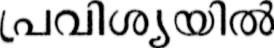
പ്രവിശ്യയില്‍
